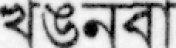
খঙনবা
